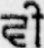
ਵੀ
